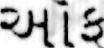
ઑફ
